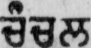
ਚੰਚਲ
